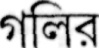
গলির
